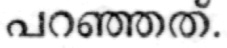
പറഞ്ഞത്.
